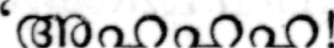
'അഹഹഹ!
